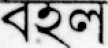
বহল
